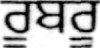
ਰੂਬਰੂ
